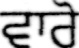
ਵਾਰੋ
